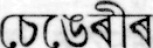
চেঙেৰীৰ
